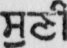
ਸੁਣੀ
